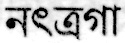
নৎত্রগা
